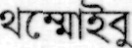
থম্মোইবু
